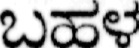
ಬಹಳ
